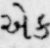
એક
